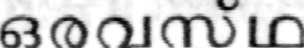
ഒരവസ്ഥ
